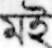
মই
